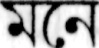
মনে
